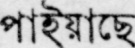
পাইয়াছে
